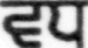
ਵਧ
